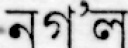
নগ'ল
